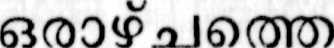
ഒരാഴ്ചത്തെ
